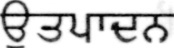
ਉਤਪਾਦਨ
